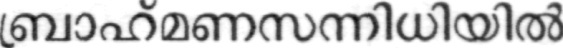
ബ്രാഹ്മണസന്നിധിയില്‍
